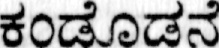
ಕಂಡೊಡನೆ
